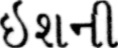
ઈશની
